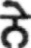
ਨੇ
